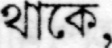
থাকে,
